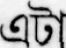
এটা
